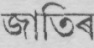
জাতিৰ
